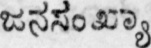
ಜನಸಂಖ್ಯಾ
